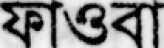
ফাওবা
